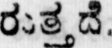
ರುತ್ತದೆ.
